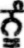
ਨੂੰ
